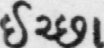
ઈચ્છા
